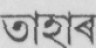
তাহাৰ
